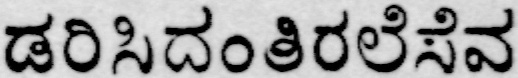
ಡರಿಸಿದಂತಿರಲೆಸೆವ
